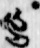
હું
